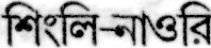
শিংলি-নাওরি
